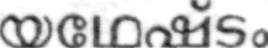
യഥേഷ്ടം
